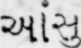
આંસુ
